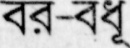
বর-বধূ
